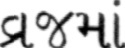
વ્રજમાં
